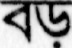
বড়
